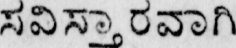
ಸವಿಸ್ತಾರವಾಗಿ
